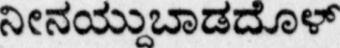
ನೀನಯ್ದುಬಾಡದೊಳ್
